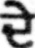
ਦੇ
